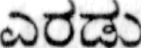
ಎರಡು
